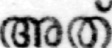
അത്
